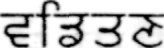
ਵਡਿਤਣ
